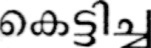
കെട്ടിച്ച
